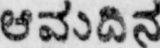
ಆಮದಿನ
